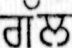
ਗੱਲ
